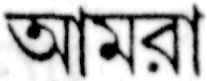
আমরা
